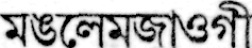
মঙলেমজাওগী
